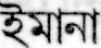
ইমানা
